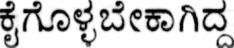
ಕೈಗೊಳ್ಳಬೇಕಾಗಿದ್ದ
